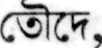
তৌদে,
